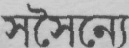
সসৈন্যে
